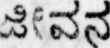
ಜೀವನ
